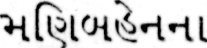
મણિબહેનના
